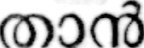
താന്‍
